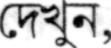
দেখুন,
